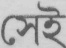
সেই
